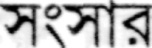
সংসার
